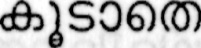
കൂടാതെ
